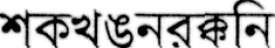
শকখঙনরক্কনি
